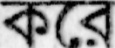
করে
